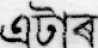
এটাৰ
